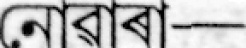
নোৱাৰা-
